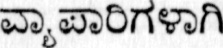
ವ್ಯಾಪಾರಿಗಳಾಗಿ
